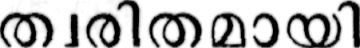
ത്വരിതമായി
